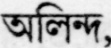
অলিন্দ,
